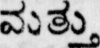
ಮತ್ತು
